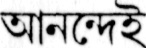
আনন্দেই
